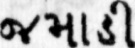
જમાડી
